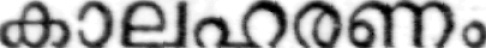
കാലഹരണം
